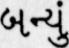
બન્યું
